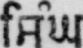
ਸਿੰਘ
